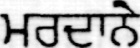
ਮਰਦਾਨੇ
